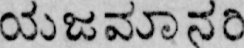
ಯಜಮಾನರಿ
